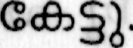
കേട്ടു.
